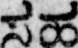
ಸಹ
